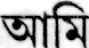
আমি
